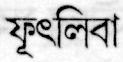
ফূৎলিবা
